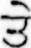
ਤੇ
